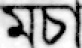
মচা
